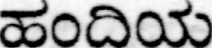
ಹಂದಿಯ
